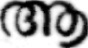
ആ
